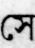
সে
